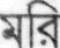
মরি
